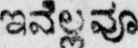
ಇವೆಲ್ಲವೂ
